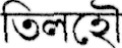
তিলহৌ
